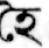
হৈ
